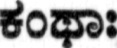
ಕಂಥಾಃ
